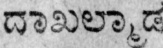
ದಾಖಲ್ಮಾಡ
